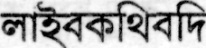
লাইবকথিবদি
